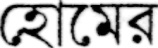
হোমের
